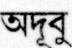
অদূবু
